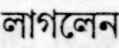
লাগলেন
